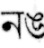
নঙ
